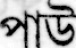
পাউ
